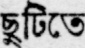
ছুটিতে
